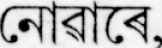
নোৱাৰে,
